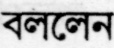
বললেন
